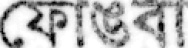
ফোঙবা
